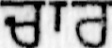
ਚਾਰ
